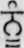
ਨੂੰ
